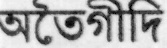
অতৈগীদি
